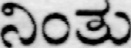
ನಿಂತು
